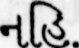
નહિ.
